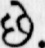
છે.
